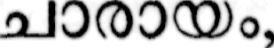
ചാരായം,
